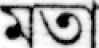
মতা
